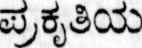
ಪ್ರಕೃತಿಯ
